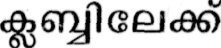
ക്ലബ്ബിലേക്ക്
